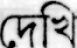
দেখি
